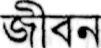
জীবন
